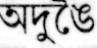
অদুঙৈ
